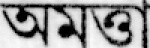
অমত্তা
